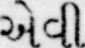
એવી
